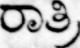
ರಾತ್ರಿ
